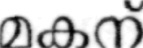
മകന്
